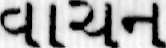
વાચન
